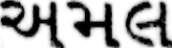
અમલ
